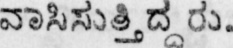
ವಾಸಿಸುತ್ತಿದ್ದರು.
